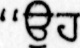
''ਉਹ
